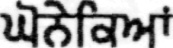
ਘੋਨੇਕਿਆਂ
